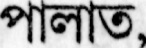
পালাত,
